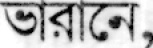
ভারানে,
